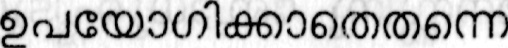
ഉപയോഗിക്കാതെതന്നെ
